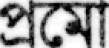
প্রমো
